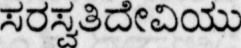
ಸರಸ್ವತಿದೇವಿಯು
